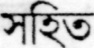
সহিত
